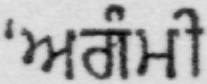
'ਅਗੰਮੀ
